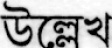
উল্লেখ
